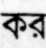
কর
